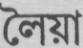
লৈয়া
